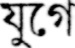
যুগে
